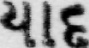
યાદ
